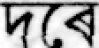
দৰে
